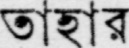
তাহার
